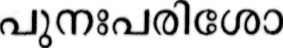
പുനഃപരിശോ
